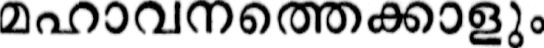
മഹാവനത്തെക്കാളും
